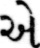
એ
